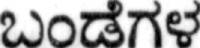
ಬಂಡೆಗಳ
